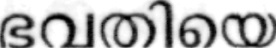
ഭവതിയെ
